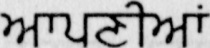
ਆਪਣੀਆਂ
